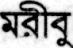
মরীবু
